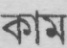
কাম
